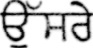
ਉੱਸਰੇ
